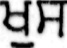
ਖੁਸ
